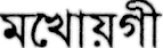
মখোয়গী
